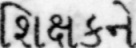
શિક્ષકને
